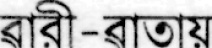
ৱারী-ৱাতায়
